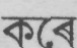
কৰে
